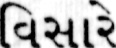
વિસારે
